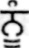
ਨੂੰ
